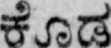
ಕೊಡ
